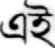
এই
